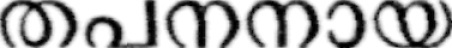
തപനനായ
